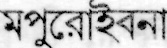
মপুরোইবনা
